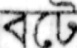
বটে
